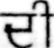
ਦੀ
